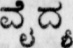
ವೈದ್ಯ
